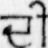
ਦੀ
